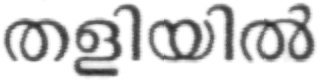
തളിയില്‍
